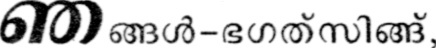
ഞങ്ങള്‍-ഭഗത്സിങ്ങ്,
